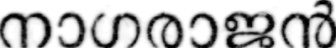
നാഗരാജന്‍
